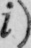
i)
